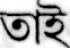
তাই
